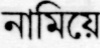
নামিয়ে
